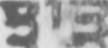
ਝਾੜ
